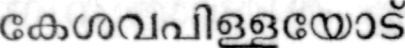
കേശവപിള്ളയോട്
